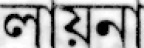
লায়না
